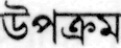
উপক্রম
